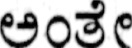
ಅಂತೇ
